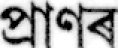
প্রাণৰ
